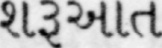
શરૂઆત
